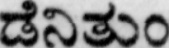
ಡೆನಿತುಂ
